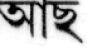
আছ
